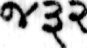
જરૂર
